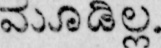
ಮೂಡಿಲ್ಲ.
